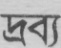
দ্ৰব্য
